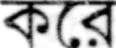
করে
